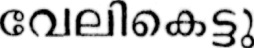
വേലികെട്ടു
